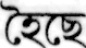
হৈছে
